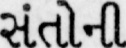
સંતોની
